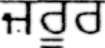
ਜ਼ਰੂਰ
